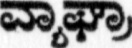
ವ್ಯಾಘ್ರಾ
